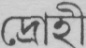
দ্ৰোহী
